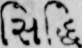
સિદ્ધિ
